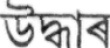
উদ্ধাৰ
